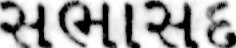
સભાસદ
